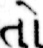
તો
